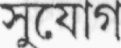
সুযোগ
